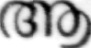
ആ
